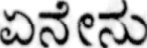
ಏನೇನು
